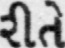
રીતે
